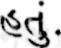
હતું.
